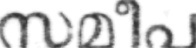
സമീപ
